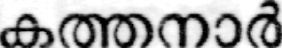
കത്തനാര്‍
